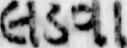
લડવા
